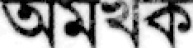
অমখক
